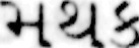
મથક
